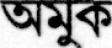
অমুক
